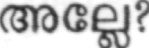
അല്ലേ?
